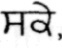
ਸਕੇ,
